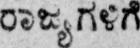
ರಾಜ್ಯಗಳಿಗೆ
